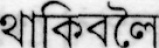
থাকিবলৈ
